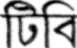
টিবি
